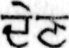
ਦੇਣ
